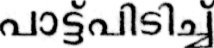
പാട്ട്പിടിച്ച്
